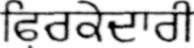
ਫ਼ਿਰਕੇਦਾਰੀ
